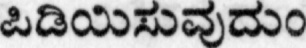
ಪಿಡಿಯಿಸುವುದುಂ
